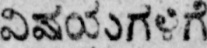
ವಿಷಯಗಳಿಗೆ
